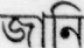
জানি
